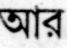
আর
